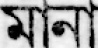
মানা
